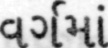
વર્ગમાં
